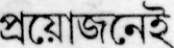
প্রয়োজনেই
